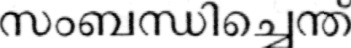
സംബന്ധിച്ചെന്ത്
